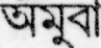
অমুবা
